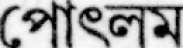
পোৎলম
